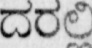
ದರಲ್ಲಿ
